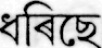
ধৰিছে
